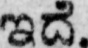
ಇದೆ.
